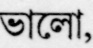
ভালো,
